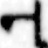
ન
